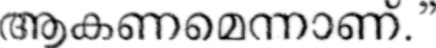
ആകണമെന്നാണ്."
